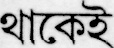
থাকেই
